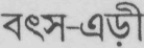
বৎস-এড়ী
